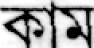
কাম
